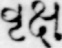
વૃક્ષ
